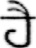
ਹੈ
